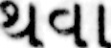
થવા
